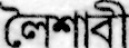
লৈশাবী
